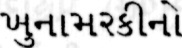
ખુનામરકીનો
